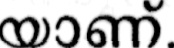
യാണ്.
